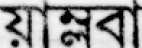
য়াম্লবা
